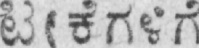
ಟೀಕೆಗಳಿಗೆ
